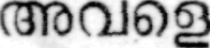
അവളെ
